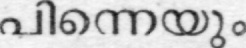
പിന്നെയും
